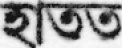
হাতত
